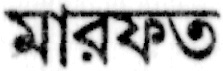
মারফত
